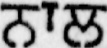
ਨਾਲ
